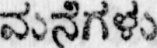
ಮನೆಗಳು
